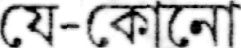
যে-কোনো
